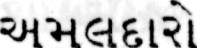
અમલદારો
